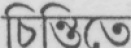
চিন্তিতে
